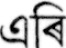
এৰি
